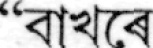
"বাখৰে
